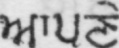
ਆਪਣੇ
